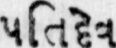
પતિદેવ
